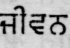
ਜੀਵਨ
